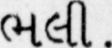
ભલી.
